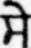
ਸੇ
